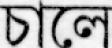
চালে
